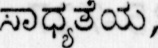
ಸಾಧ್ಯತೆಯ,
